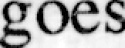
goes
